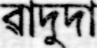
ৱাদুদা
